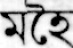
মহৈ
